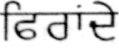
ਫਿਰਾਂਦੇ
